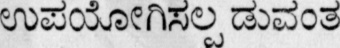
ಉಪಯೋಗಿಸಲ್ಪಡುವಂತ
